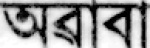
অৱাবা
